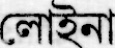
লোইনা
